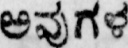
ಅವುಗಳ
